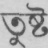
তুষ্ট
